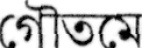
গৌতমে
